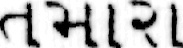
તમારા
